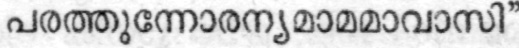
പരത്തുന്നോരന്യമാമമാവാസി"
